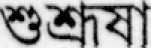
শুশ্রুষা
